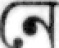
নে
